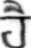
ਹੈ
